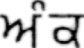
ਅੰਕ
